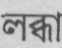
লব্ধা
